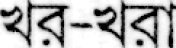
খর-খরা
